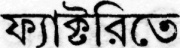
ফ্যাক্টরিতে
